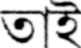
তাই
